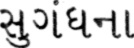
સુગંધના
